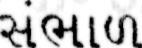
સંભાળ
